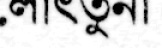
লোৎতুনা
